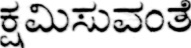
ಕ್ಷಮಿಸುವಂತೆ
